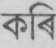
কৰি
